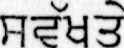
ਸਵੱਖਤੇ
